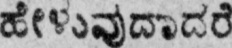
ಹೇಳುವುದಾದರೆ
